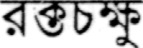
রক্তচক্ষু
